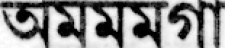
অমমমগা
